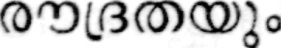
രൗദ്രതയും
